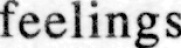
feelings
